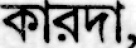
কারদা,
